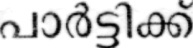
പാര്‍ട്ടിക്ക്
